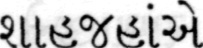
શાહજહાંએ
